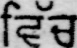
ਵਿੱਚ
